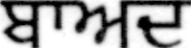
ਬਾਅਦ
